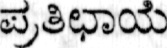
ಪ್ರತಿಛಾಯೆ
